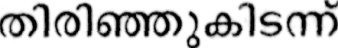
തിരിഞ്ഞുകിടന്ന്
